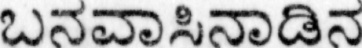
ಬನವಾಸಿನಾಡಿನ
